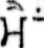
ਮੈਂ
